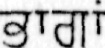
ਭਾਗਾਂ
